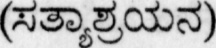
(ಸತ್ಯಾಶ್ರಯನ)
